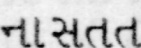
નાસતત
